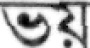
ভয়
